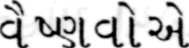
વૈષ્ણવોએ
